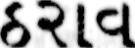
ઠરાવ
